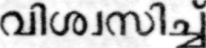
വിശ്വസിച്ച്
